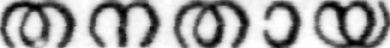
തനതായ
